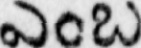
ಎಂಬ
